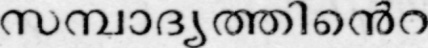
സമ്പാദ്യത്തിന്റെ
